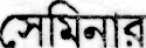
সেমিনার
